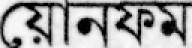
য়োনফম
